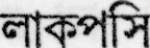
লাকপসি
